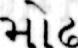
મોઢ
